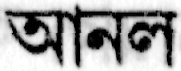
আনল
